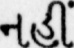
નહીં
